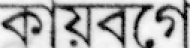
কায়বগে
